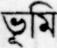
ভূমি
